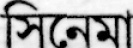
সিনেমা
